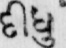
દીધું
